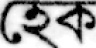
হেক
